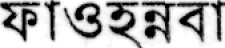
ফাওহন্নবা
